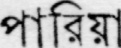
পারিয়া
